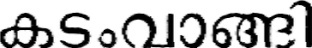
കടംവാങ്ങി
